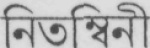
নিতম্বিনী
